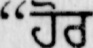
''ਹੋਰ
